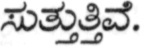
ಸುತ್ತುತ್ತಿವೆ.
